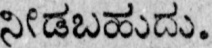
ನೀಡಬಹುದು.
